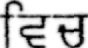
ਵਿਚ
